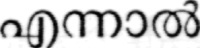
എന്നാല്‍
